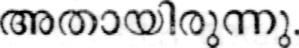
അതായിരുന്നു.
